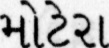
મોટેરા
